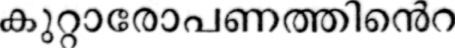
കുറ്റാരോപണത്തിന്റെ
